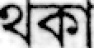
থকা
